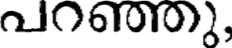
പറഞ്ഞു,
